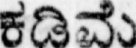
ಕಡಿಮೆ
